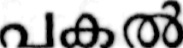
പകല്‍
